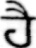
ਹੈ
